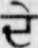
ਦੇ
